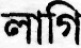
লাগি
